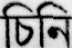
চিনি
